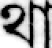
থা
